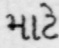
માટે
